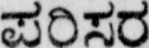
ಪರಿಸರ
